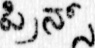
ಪ್ರಿನ್ಸ್
